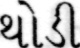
થોડી
